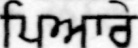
ਪਿਆਰੇ
